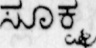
ಸೂಕ್ಷ್ಮ
